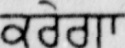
ਕਰੇਗਾ
